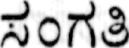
ಸಂಗತಿ
